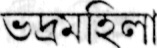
ভদ্রমহিলা
